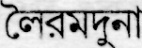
লৈরমদুনা
